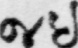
જઈ
